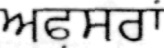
ਅਫ਼ਸਰਾਂ
